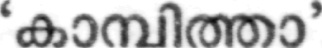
‘കാമ്പിത്താ’
